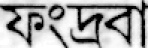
ফংদ্রবা
